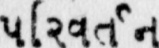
પરિવર્તન
